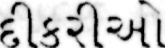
દીકરીઓ
